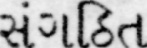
તસંગઠિત
